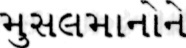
મુસલમાનોને
